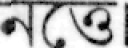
নত্তে।
